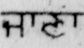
ਜਾਣਾ
